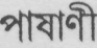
পাষাণী
